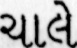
ચાલે
